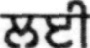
ਲਈ
